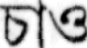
চাও
